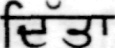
ਦਿੱਤਾ
